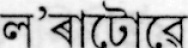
ল'ৰাটোৱে
